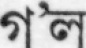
গ'ল
